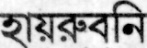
হায়রুবনি
